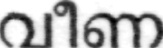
വീണ
